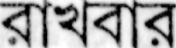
রাখবার
